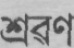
শ্ৰৱণ
